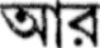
আর
